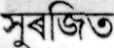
সুৰজিত
